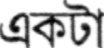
একটা
